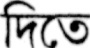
দিতে
